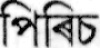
পিৰিচ
